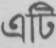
এটি
